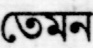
তেমন
